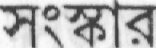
সংস্কার
